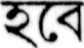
হবে
